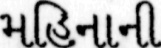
મહિનાની
